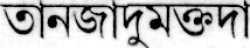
তানজাদুমক্তদা
